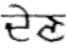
ਦੇਣ
